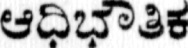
ಆಧಿಭೌತಿಕ
